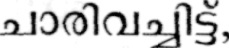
ചാരിവച്ചിട്ട്,
